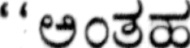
"ಅಂತಹ
